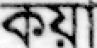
কয়া
